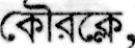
কৌরক্লে,
